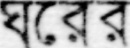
ঘরের
